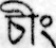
চীং
